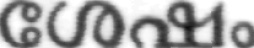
ശേഷം
